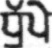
ਧੁੱਪੇ
